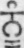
ਨੂੰ
